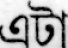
এটা
